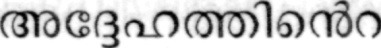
അദ്ദേഹത്തിന്റെ
